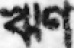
ঋণ
